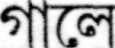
গালে
